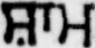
ਸ਼ਾਮ
